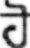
ਹੋ
